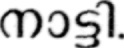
നാട്ടി.
